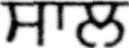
ਸਾਲ
